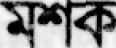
মশক
